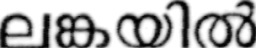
ലങ്കയില്‍
